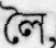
লৈ,
